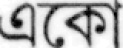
একো
